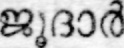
ജൂദാര്‍
